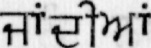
ਜਾਂਦੀਆਂ
